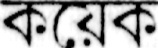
কয়েক
